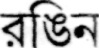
রঙিন
